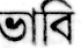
ভাবি
